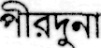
পীরদুনা
